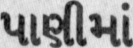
પાણીમાં
